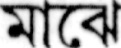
মাঝে
